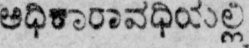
ಅಧಿಕಾರಾವಧಿಯಲ್ಲಿ
